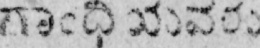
ಗಾಂಧಿಯವರು
